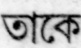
তাকে
